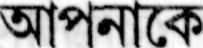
আপনাকে
